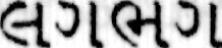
લગભગ
